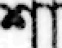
শা
